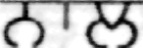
ਨਾਲ
